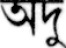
অদু
